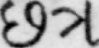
છત્ર
